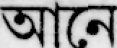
আনে
